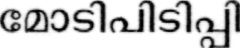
മോടിപിടിപ്പി
